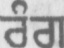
ਰੰਗ
